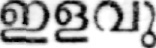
ഇളവു
